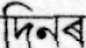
দিনৰ
